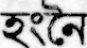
হংনৈ
